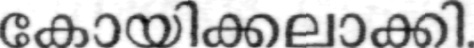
കോയിക്കലാക്കി.
